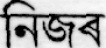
নিজৰ
